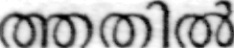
ത്തതില്‍
